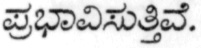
ಪ್ರಭಾವಿಸುತ್ತಿವೆ.
